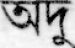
অদু
